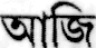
আজি
